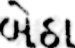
બેઠા
